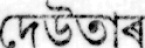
দেউতাৰ
